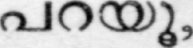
പറയൂ,
